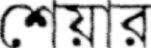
শেয়ার
